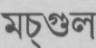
মচ্‌গুল
